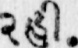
રહી.
